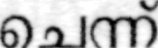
ചെന്ന്
